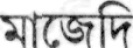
মাজেদি
